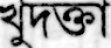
খুদক্তা
